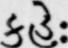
કહે:
